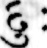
દુ
